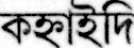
কহ্নাইদি
